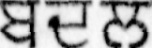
ਬਦਲ
